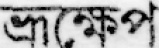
ভ্রূক্ষেপ
